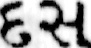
દસ
